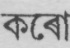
কৰো
